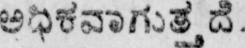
ಅಧಿಕವಾಗುತ್ತದೆ.
